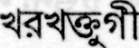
খরখক্তুগী
